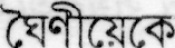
ঘৈণীয়েকে
